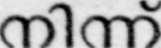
നിന്ന്
